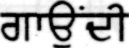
ਗਾਉਂਦੀ
